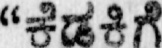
“ಕೆಡಕಿಗೆ
